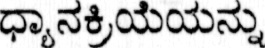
ಧ್ಯಾನಕ್ರಿಯೆಯನ್ನು
